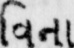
વિના
